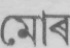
মোৰ
